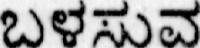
ಬಳಸುವ
